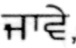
ਜਾਵੇ,
